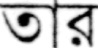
তার
